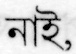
নাই,
